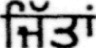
ਜਿੱਤਾਂ
